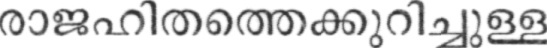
രാജഹിതത്തെക്കുറിച്ചുള്ള
